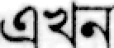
এখন
